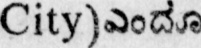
City)ಎಂದೂ
